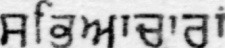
ਸਭਿਆਚਾਰਾਂ
